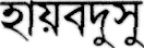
হায়বদুসু
